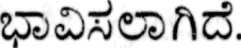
ಭಾವಿಸಲಾಗಿದೆ.
